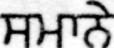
ਸਮਾਨੇ
